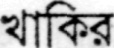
খাকির
